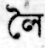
লৈ
